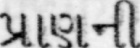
પ્રાણની
